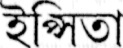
ইপ্সিতা
